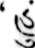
'હું
